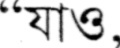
“যাও,
